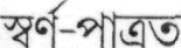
স্বৰ্ণ-পাত্ৰত
